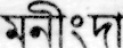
মনীংদা
